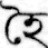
হৈ
